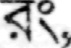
রং,
